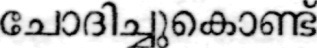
ചോദിച്ചുകൊണ്ട്
